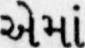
એમાં
